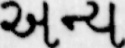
અન્ય
